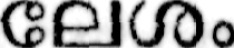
ലേശം
